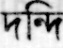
দন্দি
